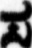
ಸ
